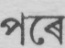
পৰে
